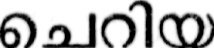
ചെറിയ
